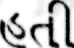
હતી
